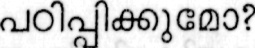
പഠിപ്പിക്കുമോ?
